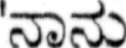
‘ನಾನು
